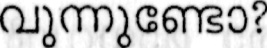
വുന്നുണ്ടോ?
